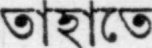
তাহাতে
